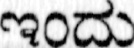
ಇಂದು
